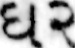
ઘર
